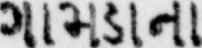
ગામડાના
